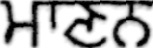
ਮਾਣਨ
